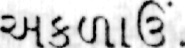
અકળાઉં.
